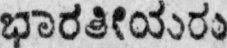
ಭಾರತೀಯರು
